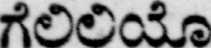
ಗೆಲಿಲಿಯೊ
